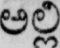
ಅಲ್ಲಿ
